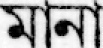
মানা
